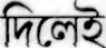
দিলেই
